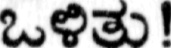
ಒಳಿತು!
